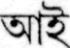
আই
